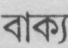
বাক্য
